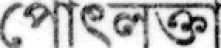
পোৎলক্তা
